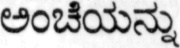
ಅಂಚೆಯನ್ನು
